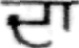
ਦਾ
